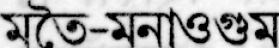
মতৈ-মনাওগুম
